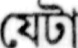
যেটা
